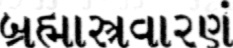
બ્રહ્માસ્ત્રવારણં
